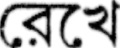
রেখে
